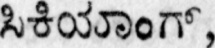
ಸಿಕಿಯಾಂಗ್,
